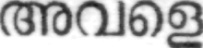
അവളെ
